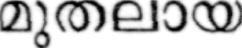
മുതലായ
